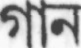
গান
